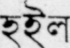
হইল
